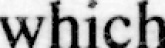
which
